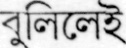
বুলিলেই
